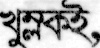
খুম্লকই,
